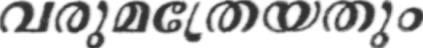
വരുമത്രേയതും
